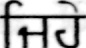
ਜਿਹੇ
